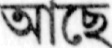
আছে
